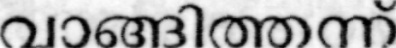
വാങ്ങിത്തന്ന്
